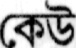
কেউ
